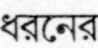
ধরনের
